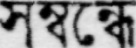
সম্বন্ধে
